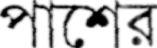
পাশের
